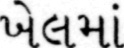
ખેલમાં
